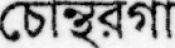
চোন্থরগা
